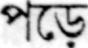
পড়ে
